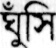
ঘুঁসি
